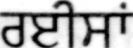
ਰਈਸਾਂ
